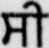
ਸੀ
